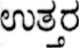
ಉತ್ತರ
